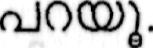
പറയൂ.
